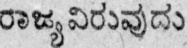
ರಾಜ್ಯವಿರುವುದು
